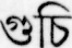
গুচি
